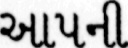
આપની
